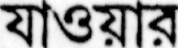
যাওয়ার
